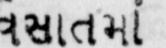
વિસાતમાં
